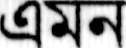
এমন
